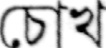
চোখ
